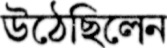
উঠেছিলেন
